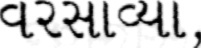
વરસાવ્યા,
